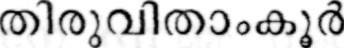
തിരുവിതാംകൂര്‍
